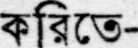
করিতে-
